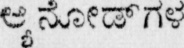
ಆನೋಡ್‌ಗಳ
